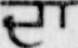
ਦਾ
